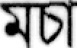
মচা
